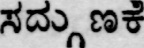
ಸದ್ಗುಣಕೆ
